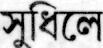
সুধিলে
